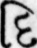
દિ
